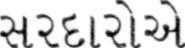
સરદારોએ
